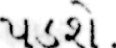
પડશે.
